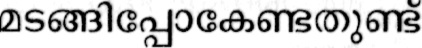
മടങ്ങിപ്പോകേണ്ടതുണ്ട്
